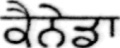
ਕੈਨੇਡਾ
